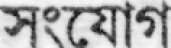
সংযোগ
